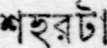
শহরটা
